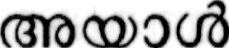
അയാള്‍
